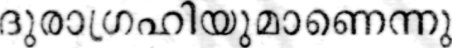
ദുരാഗ്രഹിയുമാണെന്നു
